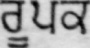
ਰੂਪਕ
